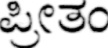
ಪ್ರೀತಂ
